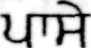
ਪਾਸੇ
